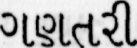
ગણતરી
